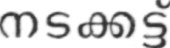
നടക്കട്ട്
